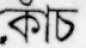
কোঁচ
